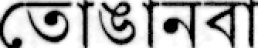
তোঙানবা
